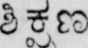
ಶಿಕ್ಷಣ
